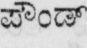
ಪೌಂಡ್
